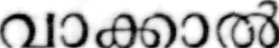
വാക്കാല്‍
